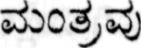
ಮಂತ್ರವು
